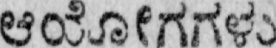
ಆಯೋಗಗಳು
